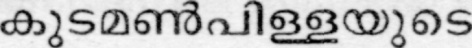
കുടമണ്‍പിള്ളയുടെ
